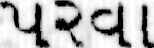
પરવા
